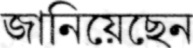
জানিয়েছেন
